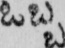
ಒಬ್ಬ
